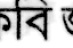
কবি
